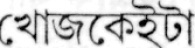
খোজকেইটা
